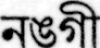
নঙগী
